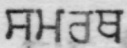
ਸਮਰਥ
